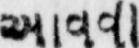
આવવી
